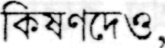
কিষণদেও,
